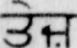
ਤੇਜ਼
